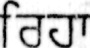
ਰਿਹਾ
